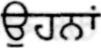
ਉਹਨਾਂ
